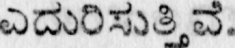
ಎದುರಿಸುತ್ತಿವೆ.
